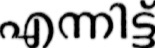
എന്നിട്ട്
